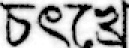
চৎখ্রে
